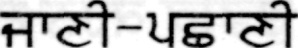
ਜਾਣੀ-ਪਛਾਣੀ
